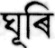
ঘূৰি
